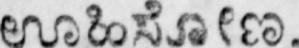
ಊಹಿಸೋಣ.
